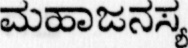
ಮಹಾಜನಸ್ಯ
